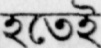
হতেই
